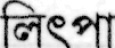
লিৎপা
